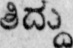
ತಿದ್ದು
